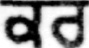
ਕਰ
